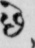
છે,
